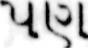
પણ
